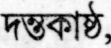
দন্তকাষ্ঠ,
